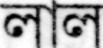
লাল
